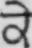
ਕੇ
